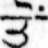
ਤੋਂ
